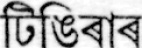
টিঙিৰাৰ
